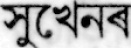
সুখেনৰ
